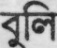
বুলি
